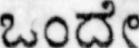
ಒಂದೇ
